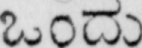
ಒಂದು
